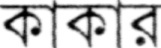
কাকার
